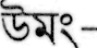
উমং-
